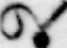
જ
